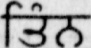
ਤਿੰਨ
